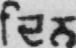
ਦਿਨ
